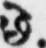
છે.
